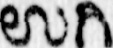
ಉಗಿ
